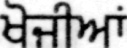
ਖੋਜੀਆਂ
